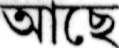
আছে
